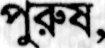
পুরুষ,
